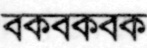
বকবকবক
